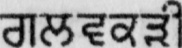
ਗਲਵਕੜੀ
